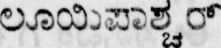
ಲೂಯಿಪಾಶ್ಚರ್
